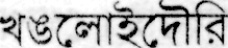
খঙলোইদৌরি
